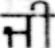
ਜੀ
